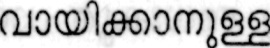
വായിക്കാനുള്ള
